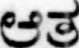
ಆತ
